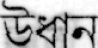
উধান
